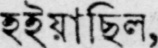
হইয়াছিল,
